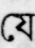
যে
